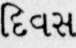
દિવસ
